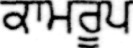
ਕਾਮਰੂਪ
